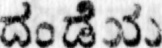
ದಂಡೆಯ
